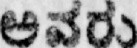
ಅವರು
